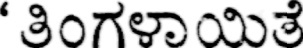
'ತಿಂಗಳಾಯಿತೆ
